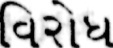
વિરોધ
